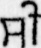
ਸੀ
